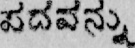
ಪದವನ್ನು
